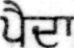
ਪੈਦਾ
